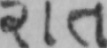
રાત
